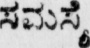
ಸಮಸ್ಯೆ
